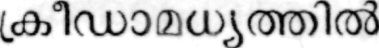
ക്രീഡാമധ്യത്തില്‍
